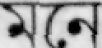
মনে
